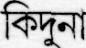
কিদুনা
